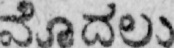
ಮೊದಲು
